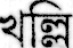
খল্লি
